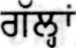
ਗੱਲ੍ਹਾਂ
